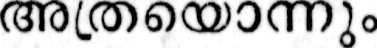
അത്രയൊന്നും
